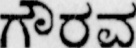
ಗೌರವ
